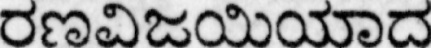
ರಣವಿಜಯಿಯಾದ
